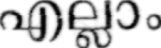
എല്ലാം
